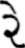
રે
